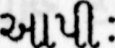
આપી:
